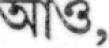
আও,
